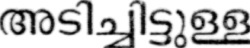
അടിച്ചിട്ടുള്ള
